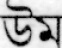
উম
